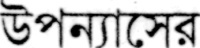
উপন্যাসের
